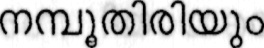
നമ്പൂതിരിയും
